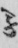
કે
